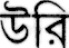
উরি
